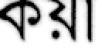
কয়া
